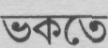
ভকতে
